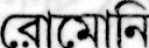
রোমোনি
